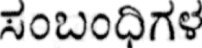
ಸಂಬಂಧಿಗಳ
